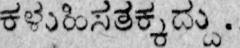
ಕಳುಹಿಸತಕ್ಕದ್ದು.
